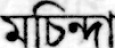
মচিন্দা
